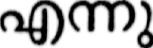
എന്നു
